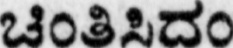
ಚಿಂತಿಸಿದಂ
